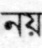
নয়
